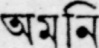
অমনি
